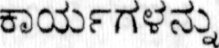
ಕಾರ್ಯಗಳನ್ನು
